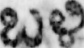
ಬಳಿ
